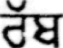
ਰੱਬ
